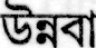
উন্নবা
